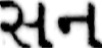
સન
